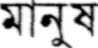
মানুষ
